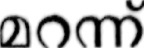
മറന്ന്
